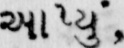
આપ્યું,
